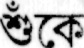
শুঁকে
